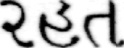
રહત
